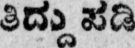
ತಿದ್ದುಪಡಿ
